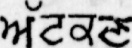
ਅੱਟਕਣ
